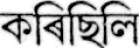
কৰিছিলি
